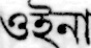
ওইনা
